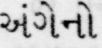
અંગેનો
